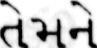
તેમને
